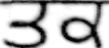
ਤਕ
